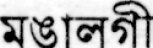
মঙালগী
